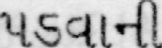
પડવાની
